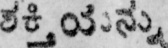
ಶಕ್ತಿಯನ್ನು
